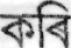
কৰি
